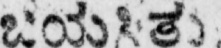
ಬಯಸಿತು.
